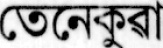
তেনেকুৱা
